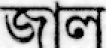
জাল
